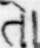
તો
